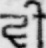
ਵੀ
